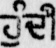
ਹੁੰਦੀ
